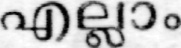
എല്ലാം
